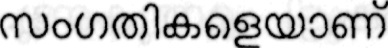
സംഗതികളെയാണ്
